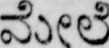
ಮೇಲೆ
